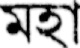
মহা
